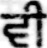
ਵੀ
